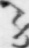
કે
